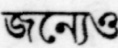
জন্যেও
